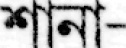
শানা-
